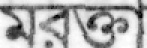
মরক্তা
